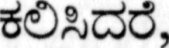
ಕಲಿಸಿದರೆ,
